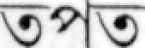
তপত
